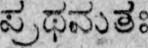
ಪ್ರಥಮತಃ
